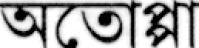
অতোপ্পা
